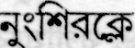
নুংশিরক্লে
